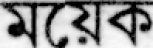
ময়েক
